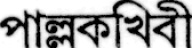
পাল্লকখিবী
